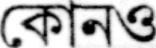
কোনও
